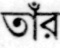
তাঁর
